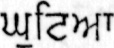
ਘੁਟਿਆ
